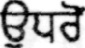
ਉਧਰੋਂ
